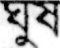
ঘুষ
